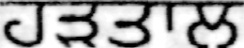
ਹੜਤਾਲ
